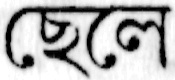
ছেলে
